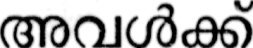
അവള്‍ക്ക്
